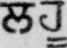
ਲਹੂ
